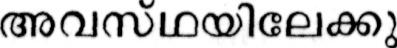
അവസ്ഥയിലേക്കു
